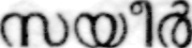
സയീര്‍
